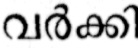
വര്‍ക്കി
